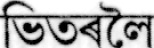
ভিতৰলৈ
